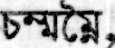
চম্মন্নৈ,
